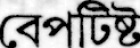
বেপটিষ্ট
